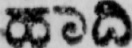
ಹಾದಿ
